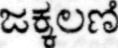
ಜಕ್ಕಲಣಿ
